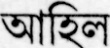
আহিল
